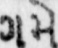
ગમે
